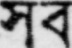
সব
